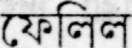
ফেলিল
